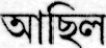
আছিল
